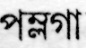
পম্লগা
